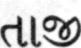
તાજી
